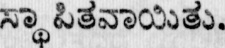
ಸ್ಥಾಪಿತವಾಯಿತು.
